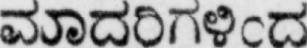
ಮಾದರಿಗಳಿಂದ
